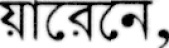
য়ারেনে,
